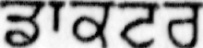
ਡਾਕਟਰ
